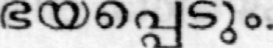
ഭയപ്പെടും.
